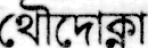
থৌদোক্না
